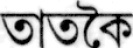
তাতকৈ
